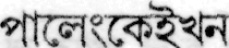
পালেংকেইখন
